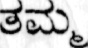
ತಮ್ಮ
